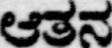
ಆತನ
